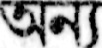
অন্য
